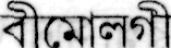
বীমোলগী
